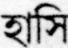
হাসি
